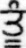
ਤੂੰ
